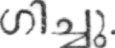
ഗിച്ചു.
